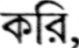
করি,
